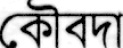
কৌবদা
